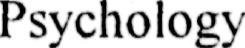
Psychology
